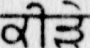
ਕੀੜੇ
